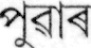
পুৱাৰ
